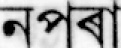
নপৰা
